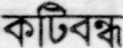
কটিবন্ধ
